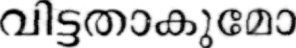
വിട്ടതാകുമോ
